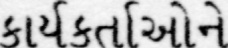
કાર્યકર્તાઓને
